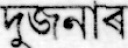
দুজনাৰ
